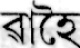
ৱাহৈ
